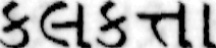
કલકત્તા
